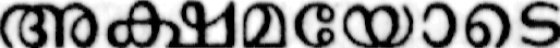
അക്ഷമയോടെ
